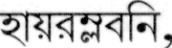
হায়রম্লবনি,
